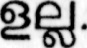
ളല്ല.
